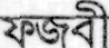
ফজবী
